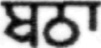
ਬਠਾ
